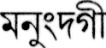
মনুংদগী
